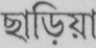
ছড়িয়া
